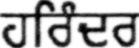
ਹਰਿੰਦਰ
